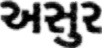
અસુર
